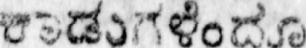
ಕಾಡುಗಳೆಂದೂ
